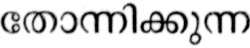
തോന്നിക്കുന്ന
